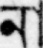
না
